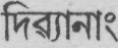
দিৱ্যানাং
